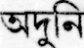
অদুনি
